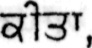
ਕੀਤਾ,
